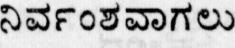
ನಿರ್ವಂಶವಾಗಲು
